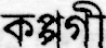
কপ্পগী
